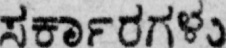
ಸರ್ಕಾರಗಳು
